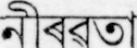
নীৰৱতা
